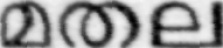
മതല
